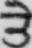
ਤੇ
